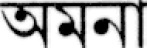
অমনা
